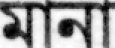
মানা
